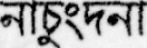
নাচুংদনা
